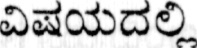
ವಿಷಯದಲ್ಲಿ
